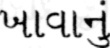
ખાવાનું
